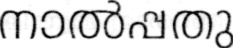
നാല്‍പ്പതു
